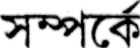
সম্পর্কে
